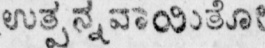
ಉತ್ಪನ್ನವಾಯಿತೋ
